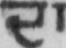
ਦਾ
